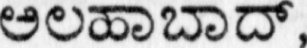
ಅಲಹಾಬಾದ್,
